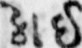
કોઈ
